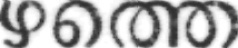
ഴത്തെ
